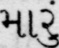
મારું
